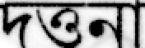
দত্তনা
